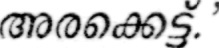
അരക്കെട്ട്.’
